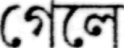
গেলে
